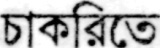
চাকরিতে
